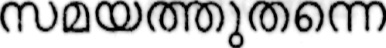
സമയത്തുതന്നെ
